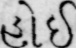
હોઈ
